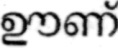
ഊണ്
